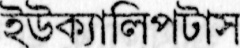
ইউক্যালিপটাস
